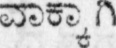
ವಾಕ್ಕಾಗಿ
